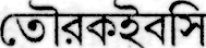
তৌরকইবসি
